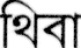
থিবা
